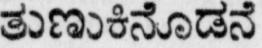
ತುಣುಕಿನೊಡನೆ
